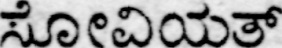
ಸೋವಿಯತ್
